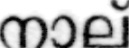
നാല്
